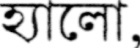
হ্যালো,
